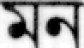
মন
